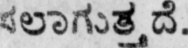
ಸಲಾಗುತ್ತದೆ.
